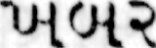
ખબર
